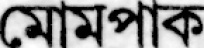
মোমপাক
